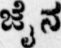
ಜೈನ
